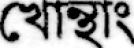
খোন্থাং
